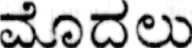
ಮೊದಲು
